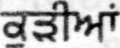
ਕੁੜੀਆਂ
